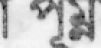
পূম্ন
